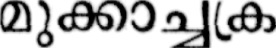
മുക്കാച്ചക്ര
